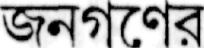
জনগণের
